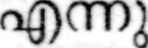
എന്നു
